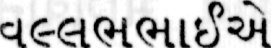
વલ્લભભાઈએ
